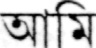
আমি
